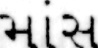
માંસ
